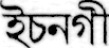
ইচনগী
